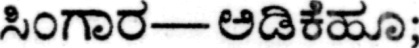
ಸಿಂಗಾರ-ಅಡಿಕೆಹೂ;
